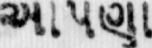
આપણા
